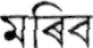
মৰিব
